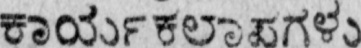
ಕಾರ್ಯಕಲಾಪಗಳು
